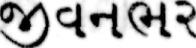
જીવનભર
